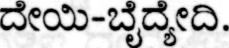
ದೇಯಿ-ಬೈದ್ಯೇದಿ.
